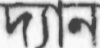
দ্যান
